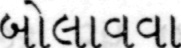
બોલાવવા
